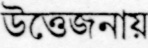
উত্তেজনায়
